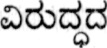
ವಿರುದ್ಧದ
